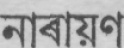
নাৰায়ণ
